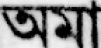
অমা
